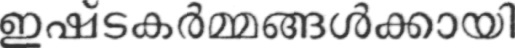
ഇഷ്ടകര്‍മ്മങ്ങള്‍ക്കായി
